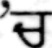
'ਚ
